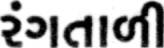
રંગતાળી
